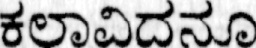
ಕಲಾವಿದನೂ
